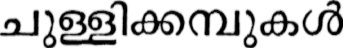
ചുള്ളിക്കമ്പുകള്‍
